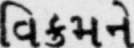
વિક્રમને
